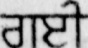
ਗਈ
